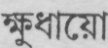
ক্ষুধায়ো
